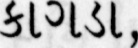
કાગડા,
